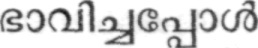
ഭാവിച്ചപ്പോള്‍
